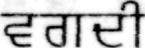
ਵਗਦੀ
